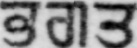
ਭਗਤ
